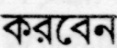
করবেন
